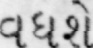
વધશે
